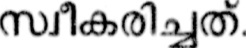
സ്വീകരിച്ചത്.
